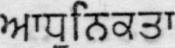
ਆਧੁਨਿਕਤਾ
